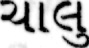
ચાલુ
